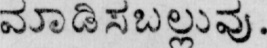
ಮಾಡಿಸಬಲ್ಲುವು.
